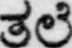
ತಲೆ
